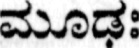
ಮೂಢಃ
